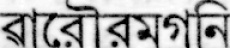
ৱারৌরমগনি
